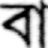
বা
